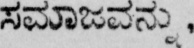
ಸಮಾಜವನ್ನು,
